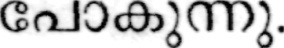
പോകുന്നു.
